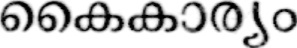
കൈകാര്യം
